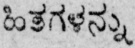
ಹಿತಗಳನ್ನು
